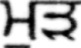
ਮੁੜ
